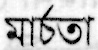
মার্চতা
